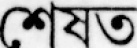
শেষত
